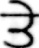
ਤੇ
